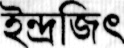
ইন্দ্রজিৎ
